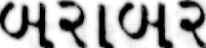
બરાબર
